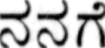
ನನಗೆ
